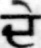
ਦੇ
